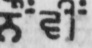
ਨੌਂਵੀਂ
